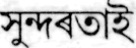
সুন্দৰতাই
